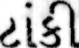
ટાંકી
